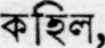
কহিল,
